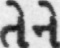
તેને
